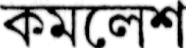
কমলেশ
